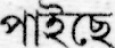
পাইছে
